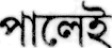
পালেই
